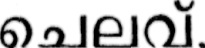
ചെലവ്.
